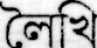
লৈখি
